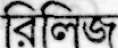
রিলিজ
